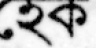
হেক
